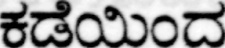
ಕಡೆಯಿಂದ
